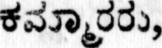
ಕಮ್ಮಾರರು,
